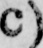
c)
